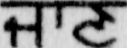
ਜਾਣ
